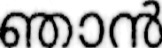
ഞാന്‍
